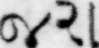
જરા
